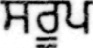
ਸਰੂਪ
